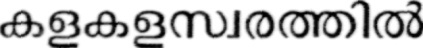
കളകളസ്വരത്തില്‍
